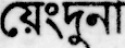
য়েংদুনা
